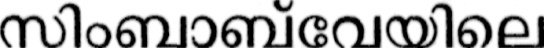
സിംബാബ്വേയിലെ
